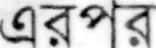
এরপর
